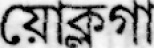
য়োক্লগা
